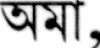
অমা,
